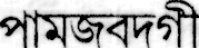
পামজবদগী
